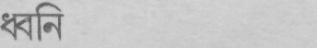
ধবনি
